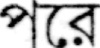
পরে
